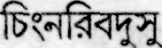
চিংনরিবদুসু
